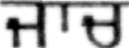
ਜਾਚ
